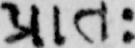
પ્રાતઃ
